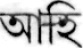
আহি
